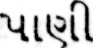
પાણી
